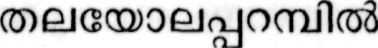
തലയോലപ്പറമ്പില്‍
